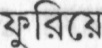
ফুরিয়ে
